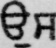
ਉਸ
